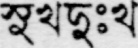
সুখদুঃখ
